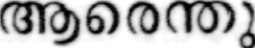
ആരെന്തു
